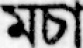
মচা
